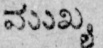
ಮುಖ್ಯ
